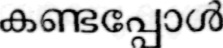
കണ്ടപ്പോള്‍
